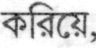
করিয়ে,
